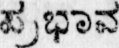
ಪ್ರಭಾವ
